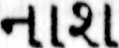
નાશ
